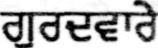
ਗੁਰਦਵਾਰੇ
